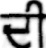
ਦੀ
